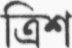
ত্রিশ
